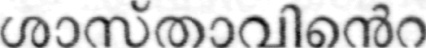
ശാസ്താവിന്റെ
